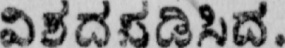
ವಿಶದಪಡಿಸಿದ.
